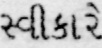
સ્વીકારે
